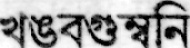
খঙবগুম্বনি
